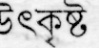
উৎকৃষ্ট
